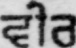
ਵੀਰ
